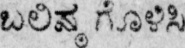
ಬಲಿಷ್ಠಗೊಳಿಸಿ
